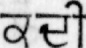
ਕਦੀ
